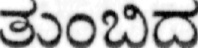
ತುಂಬಿದ
